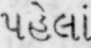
પહેલાં
